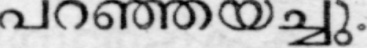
പറഞ്ഞയച്ചു.
